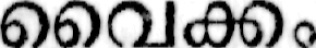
വൈക്കം
